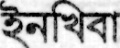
ইনখিবা
